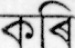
কৰি
